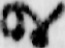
જ
